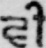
ਵੀ
